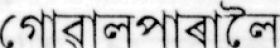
গোৱালপাৰালৈ
